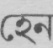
হেন
